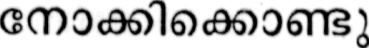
നോക്കിക്കൊണ്ടു
